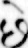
છે
